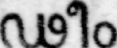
ഢീം
